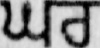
ਘਰ
